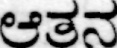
ಆತನ
